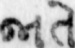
જાતે
